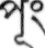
পূং
